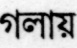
গলায়
